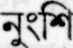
নুংশি
